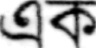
এক
